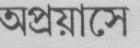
অপ্ৰয়াসে
